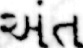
અંત
